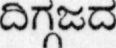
ದಿಗ್ಗಜದ
